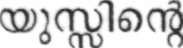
യുസ്സിന്റെ
